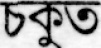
চকুত
